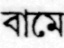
বামে
